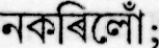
নকৰিলোঁ;
